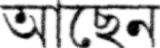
আছেন
